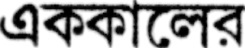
এককালের
